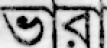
ভারা
